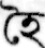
হৈ
